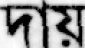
দায়
